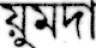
য়ুমদা
